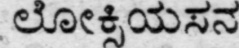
ಲೋಕ್ಸಿಯಸನ
